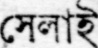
সেলাই
